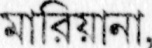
মারিয়ানা,
